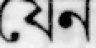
যেন
